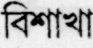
বিশাখা
